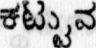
ಕಟ್ಟುವ
